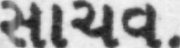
સાચવ.
